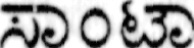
ಸಾಂಟಾ
